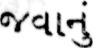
જવાનું
